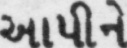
આપીને
